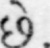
છે.
